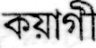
কয়াগী
